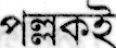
পল্লকই
